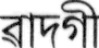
ৱাদগী
